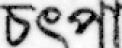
চৎপা
